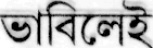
ভাবিলেই
